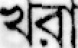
খরা
